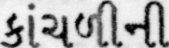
કાંચળીની
